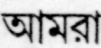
আমরা
